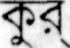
কুর্
